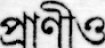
প্রাণীও
